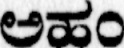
ಅಹಂ
